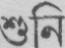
শুনি
